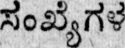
ಸಂಖ್ಯೆಗಳ
